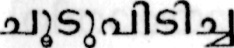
ചൂടുപിടിച്ച
